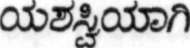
ಯಶಸ್ವಿಯಾಗಿ
